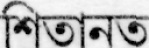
শিতানত
